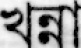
খন্না
